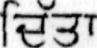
ਦਿੱਤਾ
